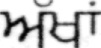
ਅੱਖਾਂ
